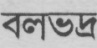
বলভদ্ৰ
